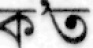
ক'ত
